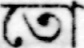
তো
